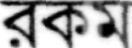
রকম
